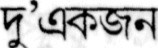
দু'একজন
